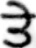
ਤੇ
